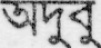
অদুবু
